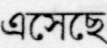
এসেছে
